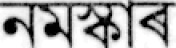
নমস্কাৰ
